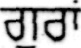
ਗੁਰਾਂ
